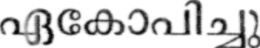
ഏകോപിച്ചു
